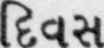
દિવસ
